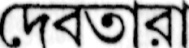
দেবতারা
